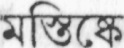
মস্তিষ্কে
